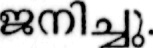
ജനിച്ചു.
